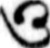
ও
